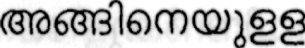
അങ്ങിനെയുളള
